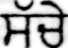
ਸੱਚੇ
